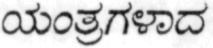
ಯಂತ್ರಗಳಾದ
